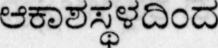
ಆಕಾಶಸ್ಥಳದಿಂದ
